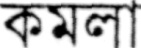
কমলা
